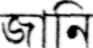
জানি
